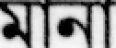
মানা
